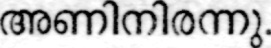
അണിനിരന്നു.
